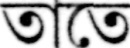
তাতে
